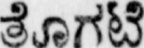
ತೊಗಟೆ
